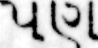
પણ
